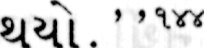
થયો."૧૪૪
